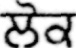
ਲੋਕ
